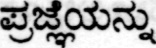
ಪ್ರಜ್ಞೆಯನ್ನು
